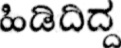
ಹಿಡಿದಿದ್ದ
